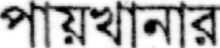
পায়খানার
